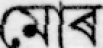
মোৰ
